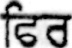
ਫਿਰ
